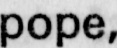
Pope,
